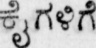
ಕೈಗಳಿಗೆ
